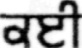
ਕਈ
